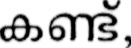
കണ്ട്,
